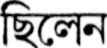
ছিলেন
